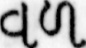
વળ
